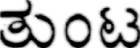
ತುಂಟ
